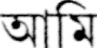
আমি
